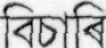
বিচাৰি
